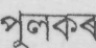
পুলকৰ
